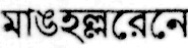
মাঙহল্লরেনে
